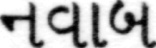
નવાબ
